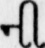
ની
